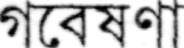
গবেষণা
